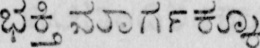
ಭಕ್ತಿಮಾರ್ಗಕ್ಕೂ
